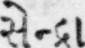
સેન્દ્રા
